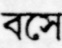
বসে
